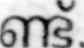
ണ്ട്.
